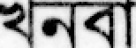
খনবা
